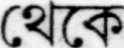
থেকে
